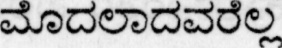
ಮೊದಲಾದವರೆಲ್ಲ
